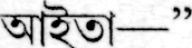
আইতা-"
